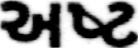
અષ્ટ
